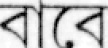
বাবে
